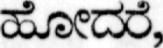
ಹೋದರೆ,
